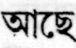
আছে
